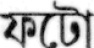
ফটো
